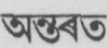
অন্তৰত
